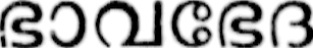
ഭാവഭേദ
